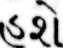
હશે
